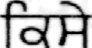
ਕਿਸੇ
